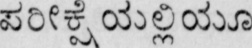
ಪರೀಕ್ಷೆಯಲ್ಲಿಯೂ
